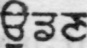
ਉਡਣ
